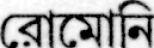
রোমোনি
